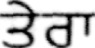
ਤੇਰਾ
